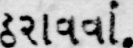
ઠરાવવાં.
